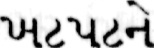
ખટપટને
